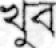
খুব
